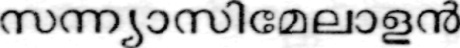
സന്ന്യാസിമേലാളന്‍
